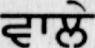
ਵਾਲੇ
